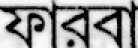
ফারবা
